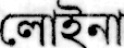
লোইনা
